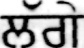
ਲੱਗੇ
